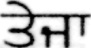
ਤੇਜਾ
